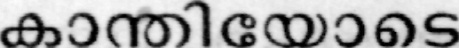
കാന്തിയോടെ
